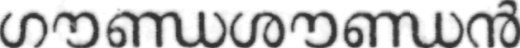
ഗൌണ്ഡശൌണ്ഡന്‍
